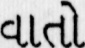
વાતો
